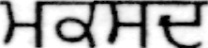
ਮਕਸਦ
